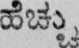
ಹೆಚ್ಚು
